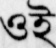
ওই
